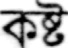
কষ্ট
